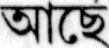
আছে
